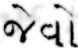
જેવો
